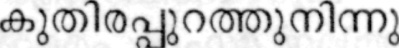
കുതിരപ്പുറത്തുനിന്നു
